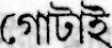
গোটাই
